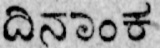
ದಿನಾಂಕ
